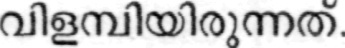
വിളമ്പിയിരുന്നത്.
